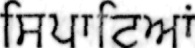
ਸਿਪਾਟਿਆਂ
